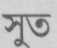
সুত
